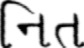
નિત
